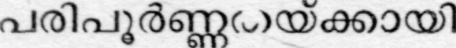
പരിപൂര്‍ണ്ണതയ്ക്കായി
